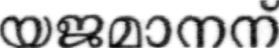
യജമാനന്
